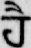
ਹੈ
